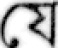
যে
